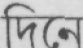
দিনে
